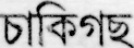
চাকিগছ
